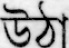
উঠা
